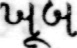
ખૂબ
